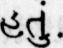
હતું.
